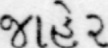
જાહેર
